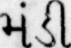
મંડી
